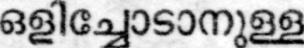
ഒളിച്ചോടാനുള്ള
